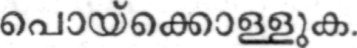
പൊയ്ക്കൊള്ളുക.
